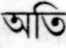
অতি
